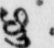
છું.
